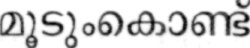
മൂടുംകൊണ്ട്
